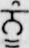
ਨੂੰ
